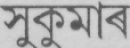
সুকুমাৰ
